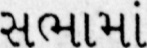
સભામાં
